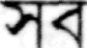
সব
